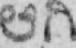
ಆಗಿ
